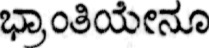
ಭ್ರಾಂತಿಯೇನೂ
